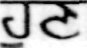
ਹੁਣ
